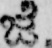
ಜೆ.
